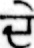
ਦੇ
